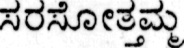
ಸರಸೋತ್ತಮ್ಮ
